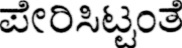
ಪೇರಿಸಿಟ್ಟಂತೆ
